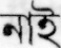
নাই
